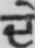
ਦੇ
